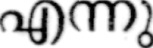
എന്നു
